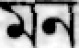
মন
